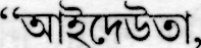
"আইদেউতা,
